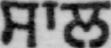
ਸਾਲ
